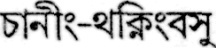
চানীং-থক্নিংবসু
